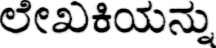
ಲೇಖಕಿಯನ್ನು
